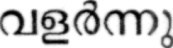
വളര്‍ന്നു
